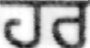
ਹਰ
